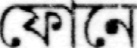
ফোনে
